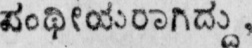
ಪಂಥೀಯರಾಗಿದ್ದು,
